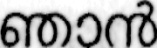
ഞാന്‍
